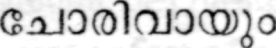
ചോരിവായും
